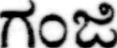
ಗಂಜಿ
